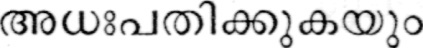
അധഃപതിക്കുകയും
